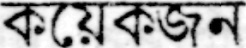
কয়েকজন
